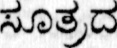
ಸೂತ್ರದ
